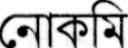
নোকমি
